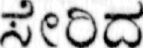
ಸೇರಿದ
